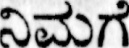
ನಿಮಗೆ
